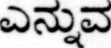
ಎನ್ನುವ
